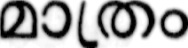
മാത്രം
